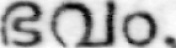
ഭവം.
